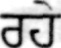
ਰਹੇ
